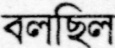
বলছিল
